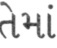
તેમાં
